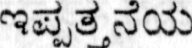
ಇಪ್ಪತ್ತನೆಯ
